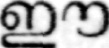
ഈ
